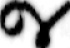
જ
